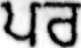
ਪਰ
